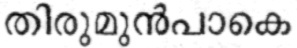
തിരുമുന്‍പാകെ
